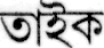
তাইক
